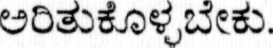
ಅರಿತುಕೊಳ್ಳಬೇಕು.
